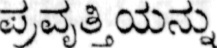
ಪ್ರವೃತ್ತಿಯನ್ನು
